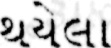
થયેલા
